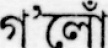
গ'লোঁ
